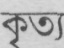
কৃত্য
